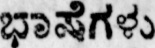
ಭಾಷೆಗಳು
